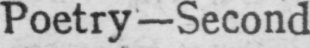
Poetry-Second
